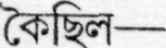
কৈছিল-
